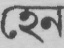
হেন
